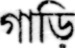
গাড়ি
